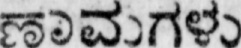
ಣಾಮಗಳು
